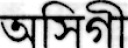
অসিগী
